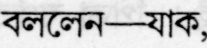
বললেন–যাক,
